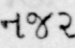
નજર
